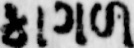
કાગળ
